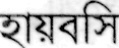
হায়বসি
